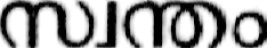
സ്വന്തം
